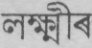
লক্ষ্মীৰ
